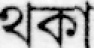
থকা
